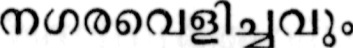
നഗരവെളിച്ചവും
